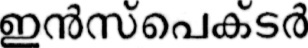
ഇന്‍സ്പെക്ടര്‍
